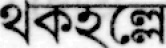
থকহল্লে
